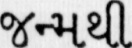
જન્મથી
